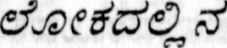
ಲೋಕದಲ್ಲಿನ
